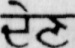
ਦੇਣ
